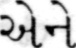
એને
